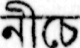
নীচে
